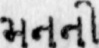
મનની
